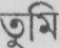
তুমি
